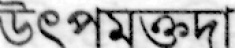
উৎপমক্তদা
